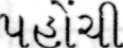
પહોંચી
